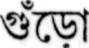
গুঁড়ো
